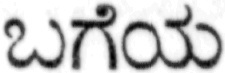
ಬಗೆಯ
